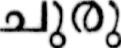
ചുരു
